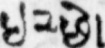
ઈચ્છો
